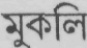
মুকলি
